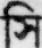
সি
